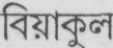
বিয়াকুল
